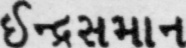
ઈન્દ્રસમાન
